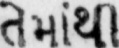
તેમાંથી
